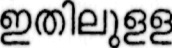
ഇതിലുള്ള
